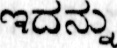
ಇದನ್ನು
